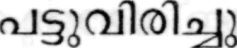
പട്ടുവിരിച്ചു
